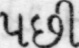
પછી
